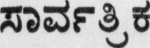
ಸಾರ್ವತ್ರಿಕ
